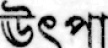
ঊৎপা
